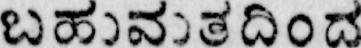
ಬಹುಮತದಿಂದ
